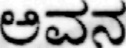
ಅವನ
